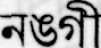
নঙগী
